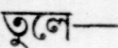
তুলে–
